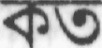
কত
